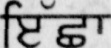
ਇੱਛਾ
